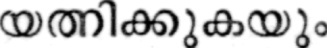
യത്നിക്കുകയും
